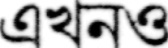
এখনও
